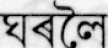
ঘৰলৈ
